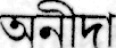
অনীদা
